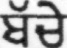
ਬੱਚੇ
